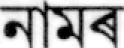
নামৰ
